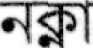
নক্না
